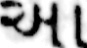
આ
